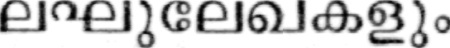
ലഘുലേഖകളും
